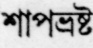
শাপভ্রষ্ট
